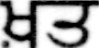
ਖ਼ਤ
